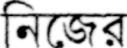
নিজের
